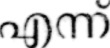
എന്ന്
